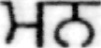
ਮਨ
